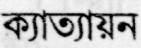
ক্যাত্যায়ন
